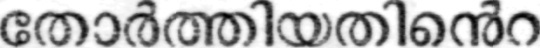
തോര്‍ത്തിയതിന്റെ
